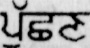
ਪੁੱਛਣ
